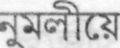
নুমলীয়ে
